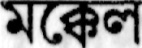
মক্কেল
